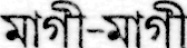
মাগী-মাগী
